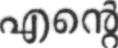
എന്റെ
